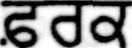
ਫ਼ਰਕ
